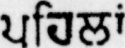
ਪਹਿਲਾਂ
